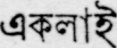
একলাই
